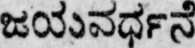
ಜಯವರ್ಧನೆ
